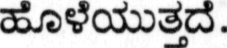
ಹೊಳೆಯುತ್ತದೆ.
